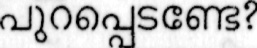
പുറപ്പെടണ്ടേ?
